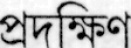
প্রদক্ষিণ
